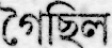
গৈছিল
